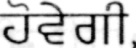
ਹੋਵੇਗੀ,
